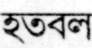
হতবল
